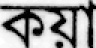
কয়া
